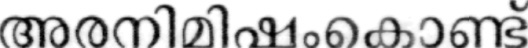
അരനിമിഷംകൊണ്ട്
